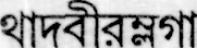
থাদবীরম্লগা
